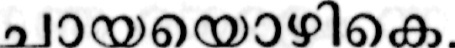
ചായയൊഴികെ.
